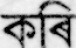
কৰি
